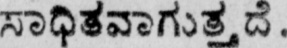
ಸಾಧಿತವಾಗುತ್ತದೆ.
